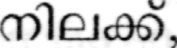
നിലക്ക്,
